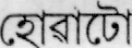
হোৱাটো
